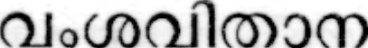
വംശവിതാന
